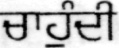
ਚਾਹੁੰਦੀ
